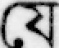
যে
